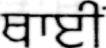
ਥਾਈਂ
